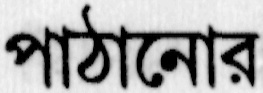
পাঠানোর
